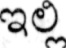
ಇಲ್ಲಿ
